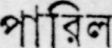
পারিল
